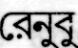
রেনুবু
